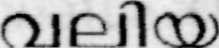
വലിയ
